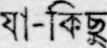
যা-কিছু
